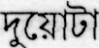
দুয়োটা
